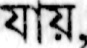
যায়,
